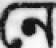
নে
